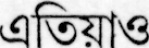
এতিয়াও
